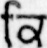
ਕਿ
